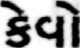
કેવો
